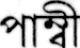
পাম্বা
